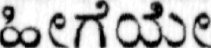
ಹೀಗೆಯೇ
